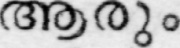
ആരും
